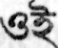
ওই
